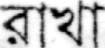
রাখা
